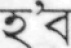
হ'ব
